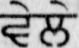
ਵੇਲੇ
